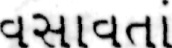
વસાવતાં
